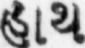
હાથ
